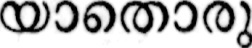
യാതൊരു
